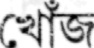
খোঁজ
